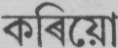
কৰিয়ো
